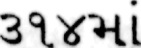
૩૧૪માં
